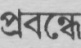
প্ৰবন্ধে
